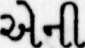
એની
